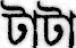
টাটা
